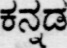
ಕನ್ನಡ
